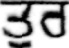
ਤੁਰ
